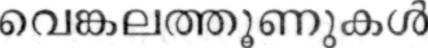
വെങ്കലത്തൂണുകള്‍
